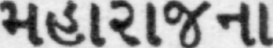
મહારાજના
